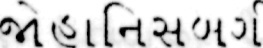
જોહાનિસબર્ગ
